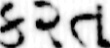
કરત
